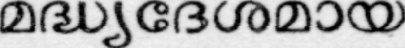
മദ്ധ്യദേശമായ
